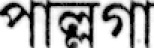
পাল্লগা
